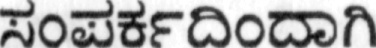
ಸಂಪರ್ಕದಿಂದಾಗಿ
